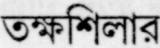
তক্ষশিলার
